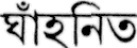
ঘাঁহনিত
